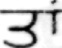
ਤਾਂ
